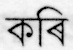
কৰি
